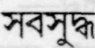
সবসুদ্ধ
